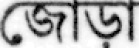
জোড়া
